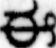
ಈ
